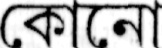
কোনো
